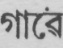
গাৱে
